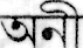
অনী
